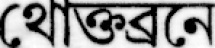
থোক্তব্রনে
